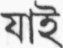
যাই
